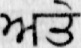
ਅਤੇ
